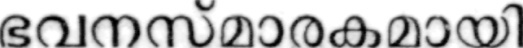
ഭവനസ്മാരകമായി
